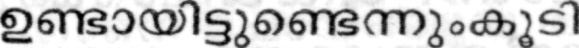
ഉണ്ടായിട്ടുണ്ടെന്നുംകൂടി
